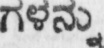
ಗಳನ್ನು
